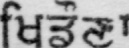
ਖਿਡੌਣਾ
